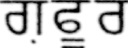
ਗ਼ਫੂਰ
